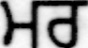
ਮਰ
